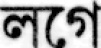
লগে
